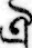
ঐ
